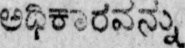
ಅಧಿಕಾರವನ್ನು
